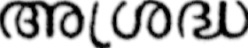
അശ്രദ്ധ
